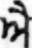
ਐ
